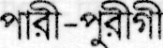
পারী-পুরীগী
